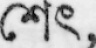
শেৎ,
